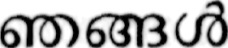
ഞങ്ങള്‍
